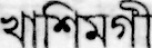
খাশিমগী
